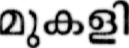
മുകളി
